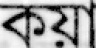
কয়া
